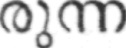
രുന്ന
